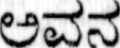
ಅವನ
